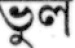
ভুল
